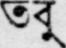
তবু
